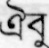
ঐবু
